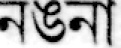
নঙনা
